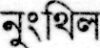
নুংথিল
